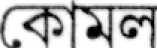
কোমল
